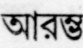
আরম্ভ
